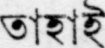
তাহাই
